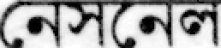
নেসনেল
